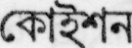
কোইশন
